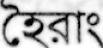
হৈরাং
